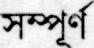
সম্পূর্ণ
